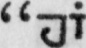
''ਹਾਂ
